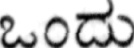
ಒಂದು
